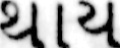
થાય
